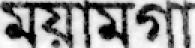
ময়ামগা
